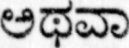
ಅಥವಾ
